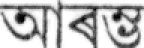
আৰম্ভ
